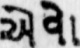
એવો
